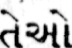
તેઓ
